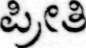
ಪ್ರೀತಿ
